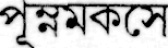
পূম্নমকসে
